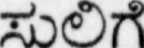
ಸುಲಿಗೆ
